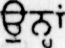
ਉਨ੍ਹਾਂ
